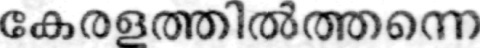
കേരളത്തില്‍ത്തന്നെ
